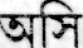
অসি
